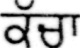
ਕੱਚਾ
